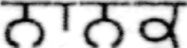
ਨਾਨਕ
